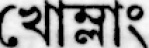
খোম্লাং
